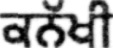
ਕਨੱਖੀ
